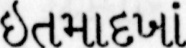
ઇતમાદખાં
